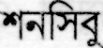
শনসিবু
